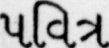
પવિત્ર
